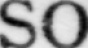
so
